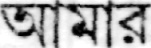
আমার
